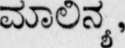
ಮಾಲಿನ್ಯ,
